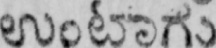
ಉಂಟಾಗು
